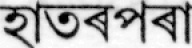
হাতৰপৰা
